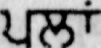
ਪਲਾਂ
